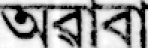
অৱাবা
